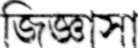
জিজ্ঞাসা
